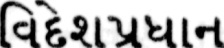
વિદેશપ્રધાન
